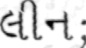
લીન;
